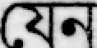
যেন
